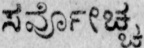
ಸರ್ವೋಚ್ಚ
